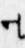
ન
